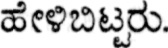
ಹೇಳಿಬಿಟ್ಟರು.
